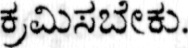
ಕ್ರಮಿಸಬೇಕು.
